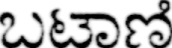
ಬಟಾಣಿ
